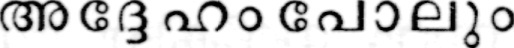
അദ്ദേഹംപോലും
